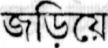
জড়িয়ে
